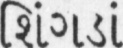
શિંગડાં
